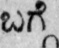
ಬಗ್ಗೆ
